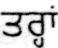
ਤਰ੍ਹਾਂ
